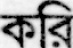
করি
